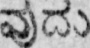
ವುದು
